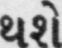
થશે
